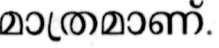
മാത്രമാണ്.
